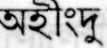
অহীংদু
